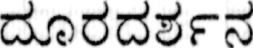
ದೂರದರ್ಶನ
